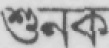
শুনক
